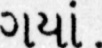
ગયાં.
